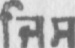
ਜਿਸ
